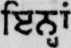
ਇਨ੍ਹਾਂ
